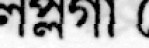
লেপ্লগা
